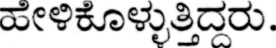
ಹೇಳಿಕೊಳ್ಳುತ್ತಿದ್ದರು.
